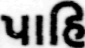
પાહિ
